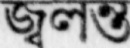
জ্বলন্ত
